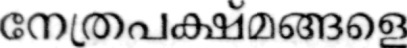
നേത്രപക്ഷ്മങ്ങളെ
